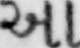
આ
